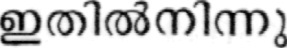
ഇതില്‍നിന്നു
